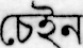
চেইন
